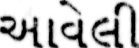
આવેલી
